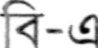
বি-এ
